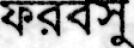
ফরবসু
